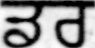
ਡਰ
